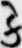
કે
